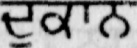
ਦੁਕਾਨ
